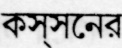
কস্সনের
